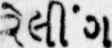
રેલીંગ
